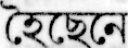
হৈছেনে
